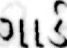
ગાર્ડ
